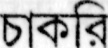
চাকরি
